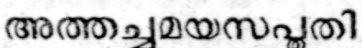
അത്തച്ചമയസപ്തതി
